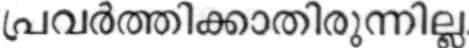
പ്രവര്‍ത്തിക്കാതിരുന്നില്ല.
